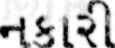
નકારી
